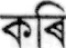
কৰি
